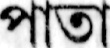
পাতা
